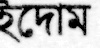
ইদোম
